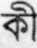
কী
